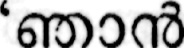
‘ഞാന്‍
